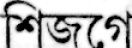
শিজগে
